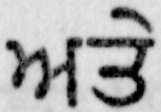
ਅਤੇ
